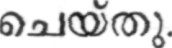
ചെയ്തു.
